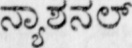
ನ್ಯಾಶನಲ್
